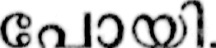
പോയി.
